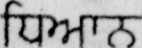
ਧਿਆਨ
